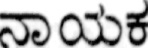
ನಾಯಕ
